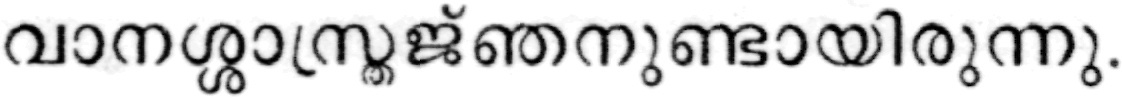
വാനശ്ശാസ്ത്രജ്ഞനുണ്ടായിരുന്നു.
